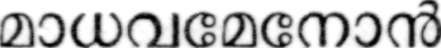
മാധവമേനോന്‍
